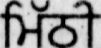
ਮਿੱਠੀ
